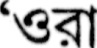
'ওরা
